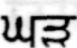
ਘੜ
